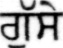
ਗੁੱਸੇ
